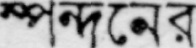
স্পন্দনের
